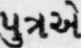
પુત્રએ
